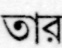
তার
